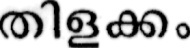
തിളക്കം
